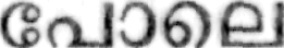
പോലെ
